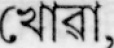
খোৱা,
